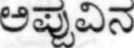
ಅಪ್ಪುವಿನ
